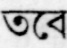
তবে
